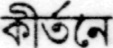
কীর্তনে
